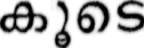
കൂടെ
